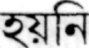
হয়নি
